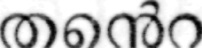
തന്റെ
